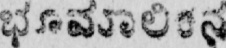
ಭೂಮಾಲಿಕನ
